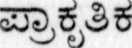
ಪ್ರಾಕೃತಿಕ
